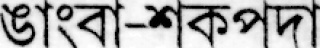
ঙাংবা-শকপদা
